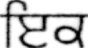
ਇਕ
